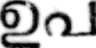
ഉപ
